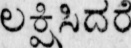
ಲಕ್ಷಿಸಿದರೆ
